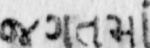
જગતમાં
